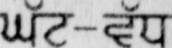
ਘੱਟ-ਵੱਧ
